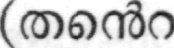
(തന്റെ
